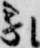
કો
